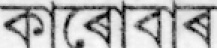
কাৰোবাৰ
